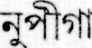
নুপীগা
